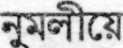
নুমলীয়ে
